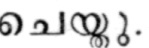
ചെയ്തു.
